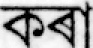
কৰা
